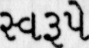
સ્વરૂપે
